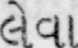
લેવા
